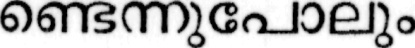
ണ്ടെന്നുപോലും
